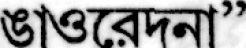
ঙাওরেদনা”
